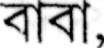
বাবা,
